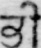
ਭੀ
